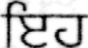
ਇਹ
